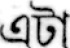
এটা
